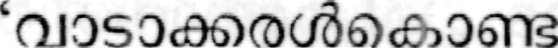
'വാടാക്കരള്‍കൊണ്ട
